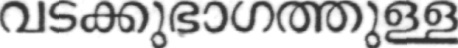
വടക്കുഭാഗത്തുള്ള
